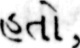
હતો,
